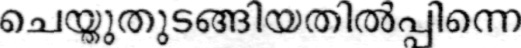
ചെയ്യുതുടങ്ങിയതില്‍പ്പിന്നെ
